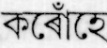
কৰোঁহে
